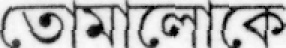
তোমালোকে
